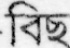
বিছ
